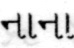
નાના
